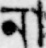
না
